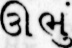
ઊભું
